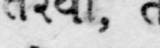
તરવા
